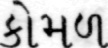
કોમળ
